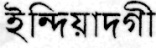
ইন্দিয়াদগী
